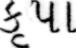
કૃપા
